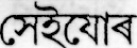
সেইযোৰ
